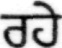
ਰਹੇ
